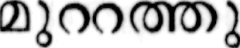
മുററത്തു
